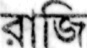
রাজি
